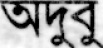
অদুবু
